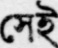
সেই
